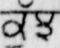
ਕੁੱਝ
